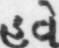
હવે
